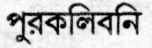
পুরকলিবনি
